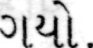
ગયો.
